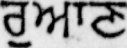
ਰੁਆਣ
